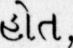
હોત,
